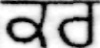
ਕਰ
